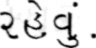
રહેવું.
